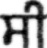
ਸੀ
